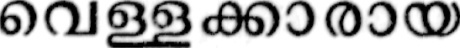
വെള്ളക്കാരായ
